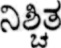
ನಿಶ್ಚಿತ
